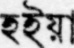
হইয়া
